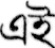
এই
